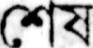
শেষ
